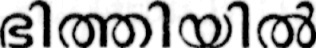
ഭിത്തിയില്‍
